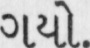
ગયો.
